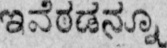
ಇವೆರಡನ್ನೂ
